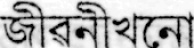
জীৱনীখনো
